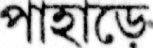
পাহাড়ে
